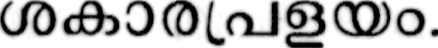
ശകാരപ്രളയം.
